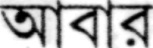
আবার
